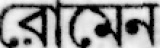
রোমেন
